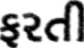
ફરતી
